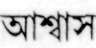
আশ্বাস
